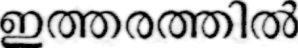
ഇത്തരത്തില്‍
